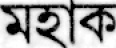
মহাক
